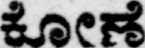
ಕೋಣೆ
